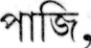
পাজি,
